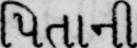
પિતાની
